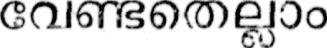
വേണ്ടതെല്ലാം
